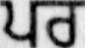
ਪਰ
